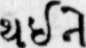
થઈને
